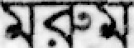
মরুম
